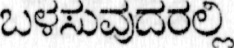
ಬಳಸುವುದರಲ್ಲಿ
